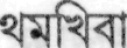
থমখিবা
